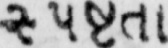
સ્પષ્ટતા
